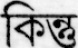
কিন্তু
